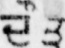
ਦੌੜ
